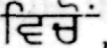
ਵਿਚੋਂ,
